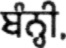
ਬੰਨ੍ਹੀ,
